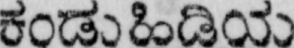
ಕಂಡುಹಿಡಿಯ
